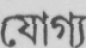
যোগ্য
